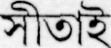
সীতাই
